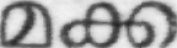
മക്ക
